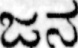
ಜನ
